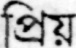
প্রিয়
